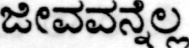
ಜೀವವನ್ನೆಲ್ಲ
